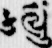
કહ્યું
